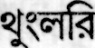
থুংলরি
